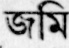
জমি
